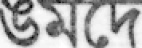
ঙমদে
